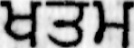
ਖਤਮ
